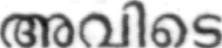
അവിടെ
